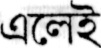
এলেই
